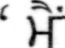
'ਮੈਂ
